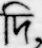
দি,
